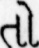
તો
